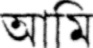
আমি
